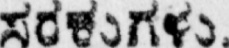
ಸರಕುಗಳು.
